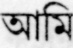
আমি
